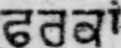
ਫਰਕਾਂ
